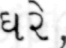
ઘરે,
